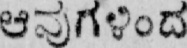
ಆವುಗಳಿಂದ
